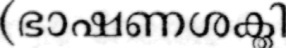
(ഭാഷണശക്തി
